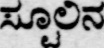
ಸ್ಪೂಲಿನ
